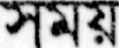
সময়
